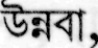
উন্নবা,
